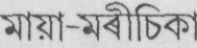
মায়া-মৰীচিকা
